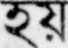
হয়
